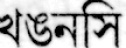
খঙনসি
